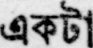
একটা
